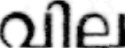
വില
